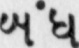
બંધ
